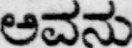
ಅವನು
